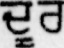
ਦੂਰ
